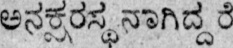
ಅನಕ್ಷರಸ್ಥನಾಗಿದ್ದರೆ
